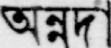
অন্নদা
